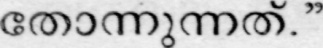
തോന്നുന്നത്."
